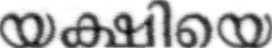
യക്ഷിയെ
